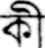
কী
